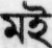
মই
